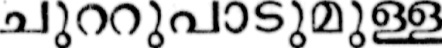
ചുററുപാടുമുള്ള
